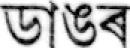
ডাঙৰ
